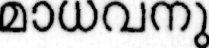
മാധവനു
